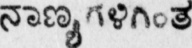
ನಾಣ್ಯಗಳಿಗಿಂತ
